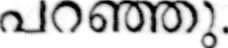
പറഞ്ഞു.
